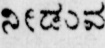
ನೀಡುವ
